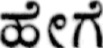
ಹೇಗೆ
